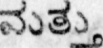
ಮತ್ತು
